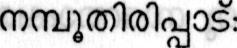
നമ്പൂതിരിപ്പാട്:
